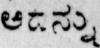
ಅದನ್ನು
